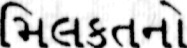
મિલકતનો
